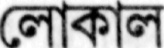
লোকাল
